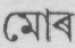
মোৰ
